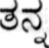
ತನ್ನ
